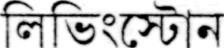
লিভিংস্টোন
